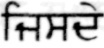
ਜਿਸਦੇ
